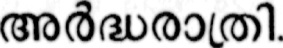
അര്‍ദ്ധരാത്രി.
